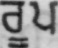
ਰੂਪ
